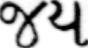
જય
